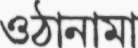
ওঠানামা
